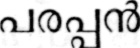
പരപ്പന്‍
